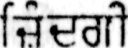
ਜ਼ਿੰਦਗੀ
